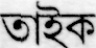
তাইক
